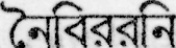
নৈবিরর‌নি
